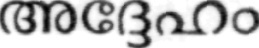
അദ്ദേഹം
